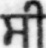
ਸੀ
